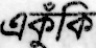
একুঁকি
